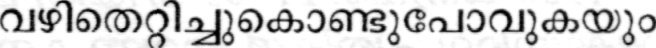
വഴിതെറ്റിച്ചുകൊണ്ടുപോവുകയും
